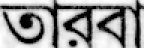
তারবা
